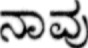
ನಾವು
